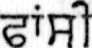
ਫਾਂਸੀ
